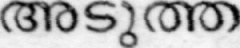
അടുത്ത
